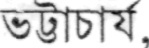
ভট্টাচার্য,
